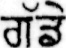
ਗੱਡੇ
